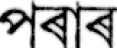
পৰাৰ
